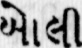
બોલી
